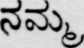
ನಮ್ಮ
